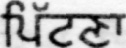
ਪਿੱਟਣਾ
